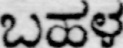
ಬಹಳ
